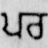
ਪਰ
